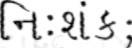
નિઃશંક;
